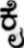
ಕೈ
